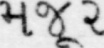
મજૂર
